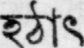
হঠাৎ
